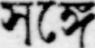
সঙ্গে
